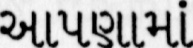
આપણામાં
